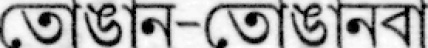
তোঙান-তোঙানবা
